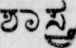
ಶಾಸ್ತ್ರ
